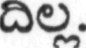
ದಿಲ್ಲ.
